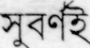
সুবৰ্ণই
